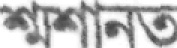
শ্মশানত
